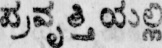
ಪ್ರವೃತ್ತಿಯಲ್ಲಿ
